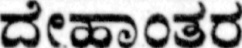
ದೇಹಾಂತರ
